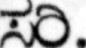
ಸರಿ.
